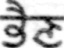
ਭੈਣ
